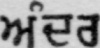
ਅੰਦਰ
